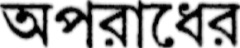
অপরাধের
